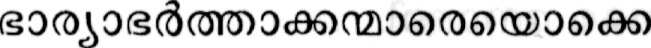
ഭാര്യാഭര്‍ത്താക്കന്മാരെയൊക്കെ
